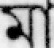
মা
